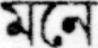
মনে
